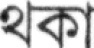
থকা
